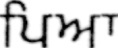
ਪਿਆ
